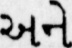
અને
